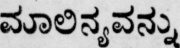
ಮಾಲಿನ್ಯವನ್ನು
